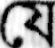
যে
